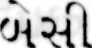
બેસી
